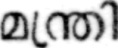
മന്ത്രി
